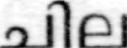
ചില
